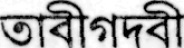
তাবীগদবী
